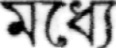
মধ্যে
